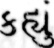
કહ્યું
